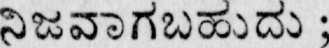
ನಿಜವಾಗಬಹುದು;
